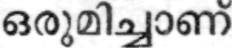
ഒരുമിച്ചാണ്
